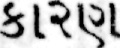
કારણ
